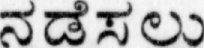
ನಡೆಸಲು
